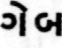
ગેબ
